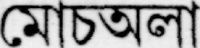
মোচঅলা
